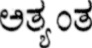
ಅತ್ಯಂತ
